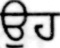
ਉਹ
